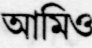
আমিও
